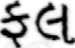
કલ
